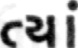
ત્યાં
